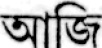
আজি
